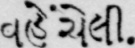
વહેંચેલી.
